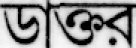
ডাক্তর
